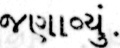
જણાવ્યું.
